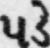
પડે
